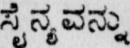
ಸೈನ್ಯವನ್ನು
